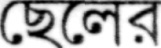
ছেলের
